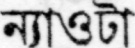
ন্যাওটা
